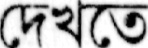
দেখতে
